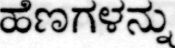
ಹೆಣಗಳನ್ನು
